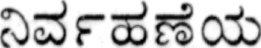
ನಿರ್ವಹಣೆಯ
